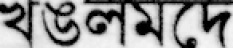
খঙলমদে
